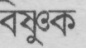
বিষ্ণুক
